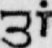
ਤਾਂ
